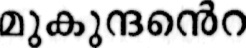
മുകുന്ദന്റെ
